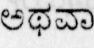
ಅಥವಾ
